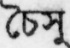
চৈসু
